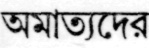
অমাত্যদের
